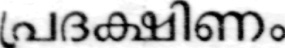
പ്രദക്ഷിണം
